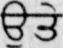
ਉਤੇ
